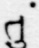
તું
